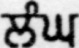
ਲੰਘ
